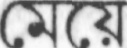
মেয়ে
